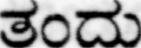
ತಂದು
